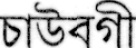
চাউবগী
